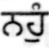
ਨਹੁੰ
